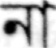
না
